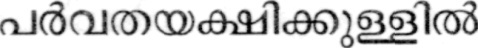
പര്‍വതയക്ഷിക്കുള്ളില്‍
